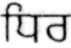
ਧਿਰ
